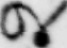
જ
